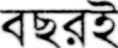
বছরই
